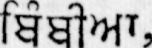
ਬਿੰਬੀਆ,
